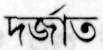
দর্জাত
